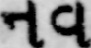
નવ
